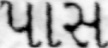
પાસ
